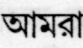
আমরা
